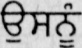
ਉਸਨੂੰ
